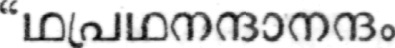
“ഥപ്രഥനന്ദാനന്ദം
